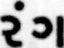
રંગ
